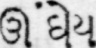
ઊંઘેય
